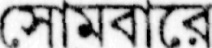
সোমবারে
